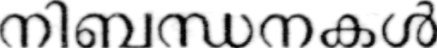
നിബന്ധനകള്‍
